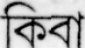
কিবা
